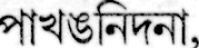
পাখঙনিদনা,
